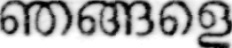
ഞങ്ങളെ
